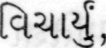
વિચાર્યું,
